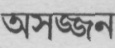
অসজ্জন
